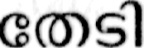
തേടി
